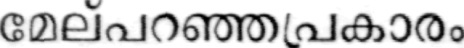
മേല്പറഞ്ഞപ്രകാരം
